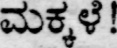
ಮಕ್ಕಳೆ!
